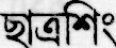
ছাত্রশিং
